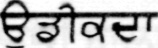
ਉਡੀਕਦਾ
